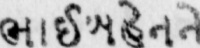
ભાઈબહેનને
